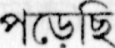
পড়েছি
